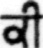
ਕੀ
